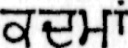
ਕਦਮਾਂ
